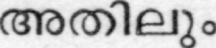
അതിലും
